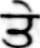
ਤੇ
